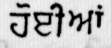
ਹੋਈਆਂ
